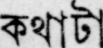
কথাটা
